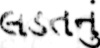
લડતનું
